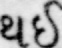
થઈ
